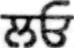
ਲਓ
